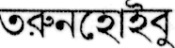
তরুনহোইবু
